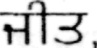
ਜੀਤ,
